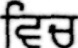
ਵਿਚ
